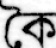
কৈ
